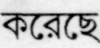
করেছে
